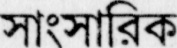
সাংসারিক
